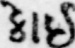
કોઈ
